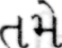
તમે
